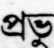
প্রভু
